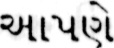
આપણે
